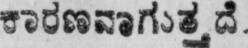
ಕಾರಣವಾಗುತ್ತದೆ.
